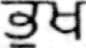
ਭੁਖ
